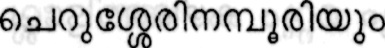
ചെറുശ്ശേരിനമ്പൂരിയും
